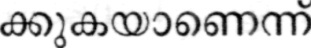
ക്കുകയാണെന്ന്
